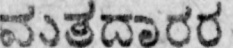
ಮತದಾರರ
